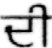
ਦੀ
